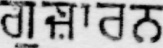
ਗੁਜ਼ਾਰਨ
